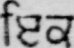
ਇਕ
